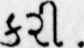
કરી.
